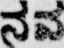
ನವ
